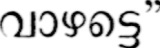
വാഴട്ടെ"
